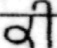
ਕੀ
